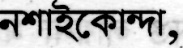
নশাইকোন্দা,
